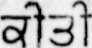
ਕੀਤੀ
